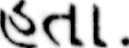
હતા.
